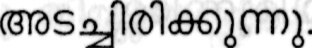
അടച്ചിരിക്കുന്നു.
